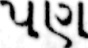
પણ
